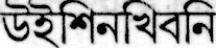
উইশিনখিবনি
